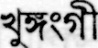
খুঙ্গংগী
